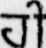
ਹੀ
